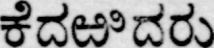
ಕೆದಱೆದರು
